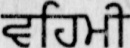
ਵਹਿਮੀ
